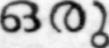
ഒരു
